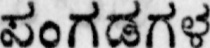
ಪಂಗಡಗಳ
